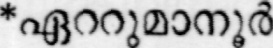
*ഏററുമാനൂര്‍
